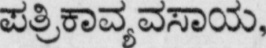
ಪತ್ರಿಕಾವ್ಯವಸಾಯ,
